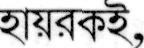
হায়রকই,
